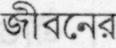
জীবনের
